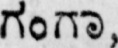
ಗಂಗಾ,
